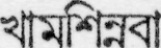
খামশিন্নবা
